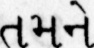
તમને
